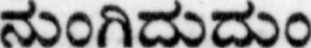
ನುಂಗಿದುದುಂ
